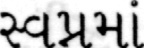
સ્વપ્નમાં
